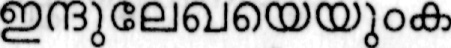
ഇന്ദുലേഖയെയുംക
